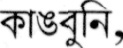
কাঙবুনি,
